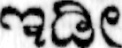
ಇಡೀ
